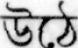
উঠে
